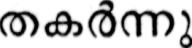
തകര്‍ന്നു
